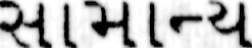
સામાન્ય
